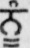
ਨੂੰ
